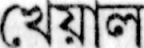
খেয়াল
